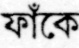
ফাঁকে
